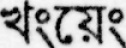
খংয়েং
